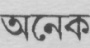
অনেক
